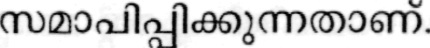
സമാപിപ്പിക്കുന്നതാണ്.
